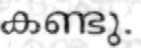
കണ്ടു.
